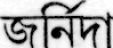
জর্নিদা
